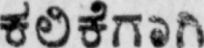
ಕಲಿಕೆಗಾಗಿ
